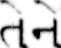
તેને
